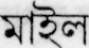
মাইল
